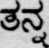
ತನ್ನ
